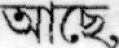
আছে,
